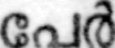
പേര്‍
